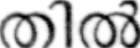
തില്‍
